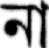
না
